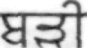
ਬੜੀ
